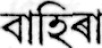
বাহিৰা
